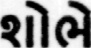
શોભે
